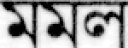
মমল
